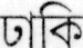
ঢাকি
